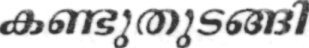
കണ്ടുതുടങ്ങി
